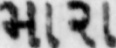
મારા
